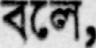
বলে,
